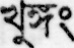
খুঙ্গং
